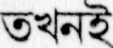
তখনই
